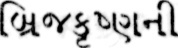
બ્રિજકૃષ્ણની
